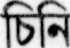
চিনি
